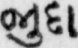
જુદા
